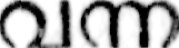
വന്ന
